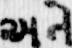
અને
